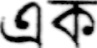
এক
